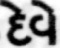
દેવે
